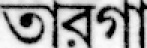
তারগা
